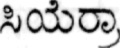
ಸಿಯೆರ್ರಾ
